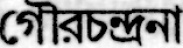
গৌরচন্দ্রনা
